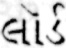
લૉર્ડ
